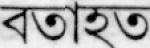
বতাহত
